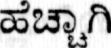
ಹೆಚ್ಚಾಗಿ
